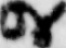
જ
